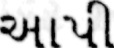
આપી
